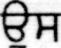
ਉਸ
